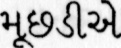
મૂછડીએ
